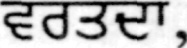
ਵਰਤਦਾ,
